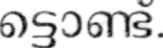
ട്ടൊണ്ട്.
